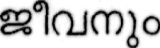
ജീവനും
